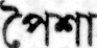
পৈশা
